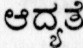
ಆದ್ಯತೆ
